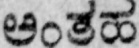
ಅಂತಹ
